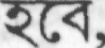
হবে,
